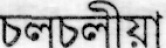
চলচলীয়া
